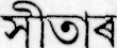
সীতাৰ
